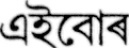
এইবোৰ
